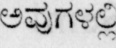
ಅವುಗಳಲ್ಲಿ
